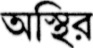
অস্থির
